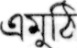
এমুঠি
